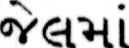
જેલમાં
